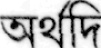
অর্থদি
